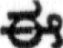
ಈ
